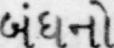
બંધનો
